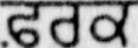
ਫ਼ਰਕ
